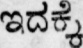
ಇದಕ್ಕೆ
